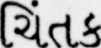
ચિંતક
